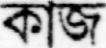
কাজ
